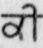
ਕੀ
